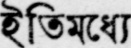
ইতিমধ্যে
